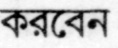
করবেন
